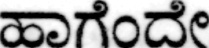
ಹಾಗೆಂದೇ
